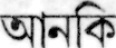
আনকি
